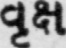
વૃક્ષ
